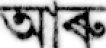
আৰু
